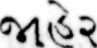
જાહેર
